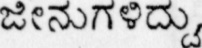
ಜೀನುಗಳಿದ್ದು,
